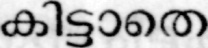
കിട്ടാതെ
